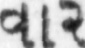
વાર
